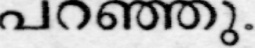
പറഞ്ഞു.
